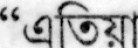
"এতিয়া
